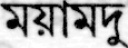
ময়ামদু
